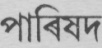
পাৰিষদ
